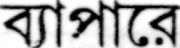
ব্যাপারে
